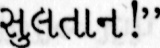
સુલતાન!"
